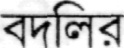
বদলির
